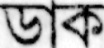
ডাক
